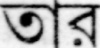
তার
